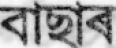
বাছাৰ
